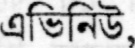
এভিনিউ,
